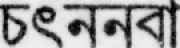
চৎননবা
